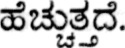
ಹೆಚ್ಚುತ್ತದೆ.
